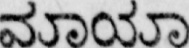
ಮಾಯಾ
